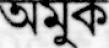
অমুক
